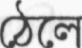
ঠেলে
